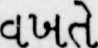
વખતે
